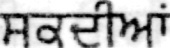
ਸਕਦੀਆਂ
